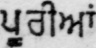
ਪੂਰੀਆਂ
